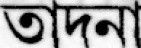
তাদনা
